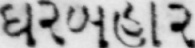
ઘરબહાર
